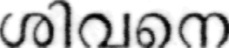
ശിവനെ
